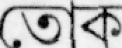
তোক
